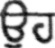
ਉਹ
